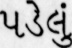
પડેલું
